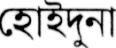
হোইদুনা
